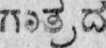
ಗಾತ್ರದ
